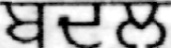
ਬਦਲ
